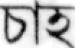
চাহ
